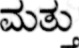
ಮತ್ತು
